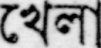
খেলা
